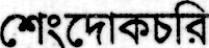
শেংদোকচরি
